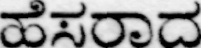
ಹೆಸರಾದ
